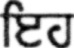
ਇਹ
